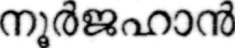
നൂര്‍ജഹാന്‍
